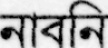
নাবনি
